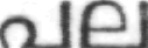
പല
